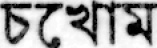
চখোম
